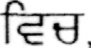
ਵਿਚ,
